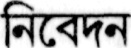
নিবেদন
